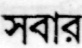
সবার
